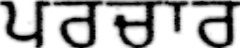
ਪਰਚਾਰ
